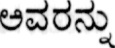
ಅವರನ್ನು
